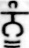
ਨੂੰ
